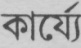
কাৰ্য্যে
